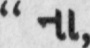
"ના,
